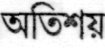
অতিশয়
